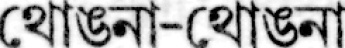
থোঙনা-থোঙনা
